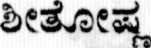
ಶೀತೋಷ್ಣ
